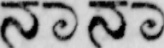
ನಾನಾ
